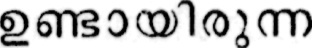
ഉണ്ടായിരുന്ന
